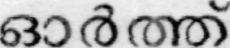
ഓര്‍ത്ത്
